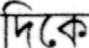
দিকে
